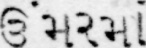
ઉંમરમાં
